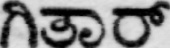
ಗಿತಾರ್
